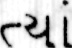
ત્યાં
